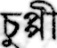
চুপ্পী
